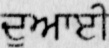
ਦੁਆਈ
